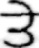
ਤੇ
